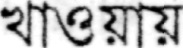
খাওয়ায়
